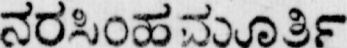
ನರಸಿಂಹಮೂರ್ತಿ
